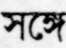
সঙ্গে
